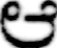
ಆ
